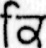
ਕਿ
